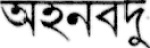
অহনবদু
